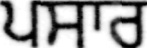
ਪਸਾਰ
